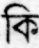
কি
